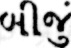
બીજું
